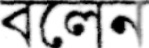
বলেন
